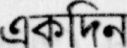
একদিন
